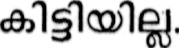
കിട്ടിയില്ല.
